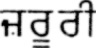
ਜ਼ਰੂਰੀ
